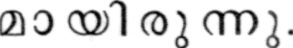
മായിരുന്നു.
